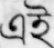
এই
